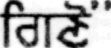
ਗਿਣੋ''
